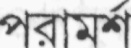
পরামর্শ
